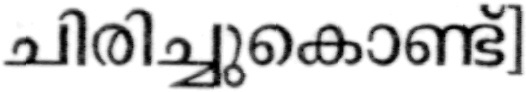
ചിരിച്ചുകൊണ്ട്]
